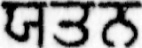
ਯਤਨ
